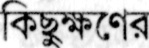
কিছুক্ষণের
